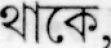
থাকে,
